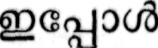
ഇപ്പോള്‍
